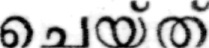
ചെയ്ത്
